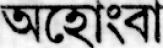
অহোংবা
